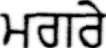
ਮਗਰੇ
